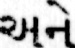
અને
